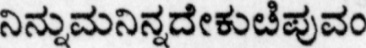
ನಿನ್ನುಮನಿನ್ನದೇಕುೞಪುವಂ
